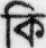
কি
